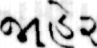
જાહેર
